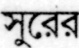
সুরের
